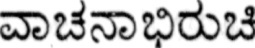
ವಾಚನಾಭಿರುಚಿ
